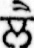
ਲੈ
